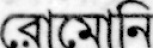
রোমোনি
